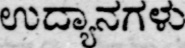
ಉದ್ಯಾನಗಳು
